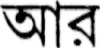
আর
